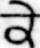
ਕੇ
